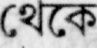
থেকে
